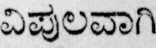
ವಿಪುಲವಾಗಿ
